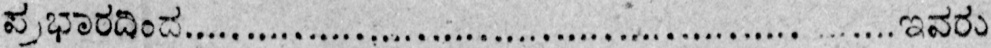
ಪ್ರಭಾರದಿಂದ..................................................................................ಇವರು
